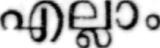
എല്ലാം
